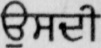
ਉਸਦੀ
